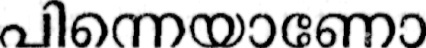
പിന്നെയാണോ
